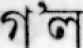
গ'ল
